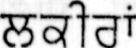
ਲਕੀਰਾਂ
